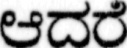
ಆದರೆ
